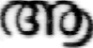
ആ
